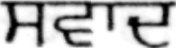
ਸਵਾਦ
